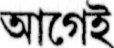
আগেই
